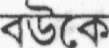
বউকে
